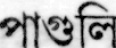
পাগুলি
